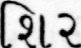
શિર
